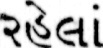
રહેલાં
